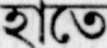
হাতে
